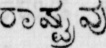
ರಾಷ್ಟ್ರವು
